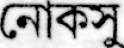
নোকসু
